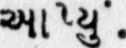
આપ્યું.
